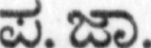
ಪ.ಜಾ.
